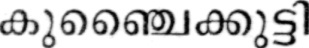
കുഞ്ചൈക്കുട്ടി
